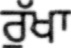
ਰੁੱਖਾ
